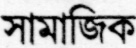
সামাজিক
